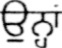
ਉਨ੍ਹਾਂ
